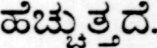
ಹೆಚ್ಚುತ್ತದೆ.
